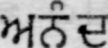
ਅਨੰਦ
